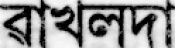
ৱাখলদা
